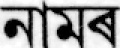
নামৰ
